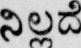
ನಿಲ್ಲದೆ
